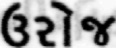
ઉરોજ
